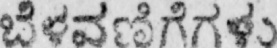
ಬೆಳವಣಿಗೆಗಳು
